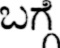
ಬಗ್ಗೆ
